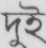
দুই
